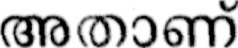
അതാണ്
